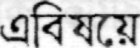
এবিষয়ে
